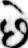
છે
